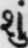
શું
